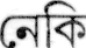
নেকি
